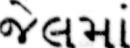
જેલમાં
